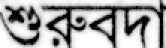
শুরুবদা
